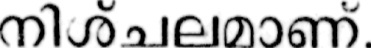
നിശ്ചലമാണ്.
